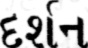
દર્શન
